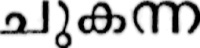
ചുകന്ന
